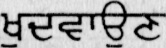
ਖੁਦਵਾਉਣ
